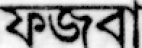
ফজবা
